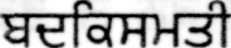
ਬਦਕਿਸਮਤੀ
